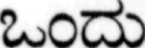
ಒಂದು
